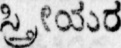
ಸ್ತ್ರೀಯರ
